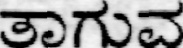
ತಾಗುವ
